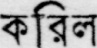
করিল
